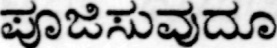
ಪೂಜಿಸುವುದೂ
